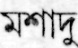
মশাদু
